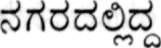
ನಗರದಲ್ಲಿದ್ದ
